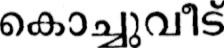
കൊച്ചുവീട്
